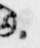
છે.
